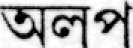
অলপ
